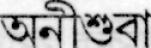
অনীশুবা
